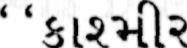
"કાશ્મીર
